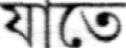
যাতে
